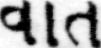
વાત
